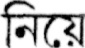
নিয়ে
